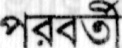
পরবর্তী
